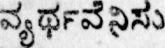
ವ್ಯರ್ಥವೆನಿಸು
